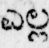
ಎಲ್ಲ
